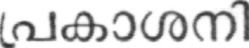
പ്രകാശനി
